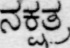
ನಕ್ಷತ್ರ
